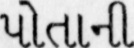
પોતાની
